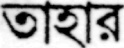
তাহার
